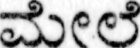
ಮೇಲೆ
